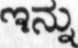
ಇನ್ನು
